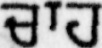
ਚਾਹ
